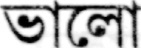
ভালো
